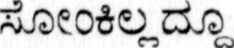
ಸೋಂಕಿಲ್ಲದ್ದೂ
